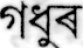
গধুৰ
